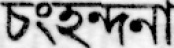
চংহন্দনা
